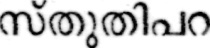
സ്തുതിപറ
